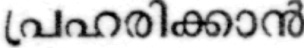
പ്രഹരിക്കാന്‍
